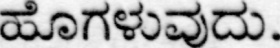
ಹೊಗಳುವುದು.
